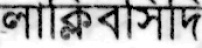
লাক্লিবসিদি
